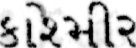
કાશ્મીર
